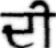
ਦੀ
